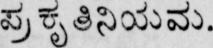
ಪ್ರಕೃತಿನಿಯಮ.
